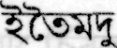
ইতৈমদু
